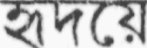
হৃদয়ে
